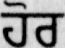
ਹੋਰ
